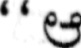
"ಆ
